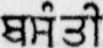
ਬਸੰਤੀ
